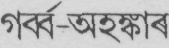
গৰ্ব্ব-অহঙ্কাৰ
